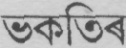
ভকতিৰ
